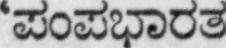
‘ಪಂಪಭಾರತ
